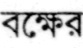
বক্ষের
